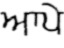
ਆਪੇ
